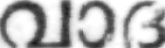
വാദ
